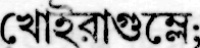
খোইরাগুম্লে;
